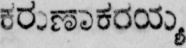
ಕರುಣಾಕರಯ್ಯ
